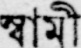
স্বামী
